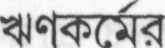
ঋণকর্মের
